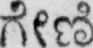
ಗೇಣಿ
